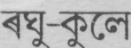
ৰঘু-কুলে
